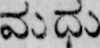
ಮಧು
